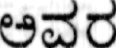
ಅವರ
